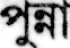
পুন্না
